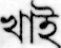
খাই
